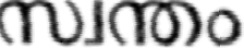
സ്വന്തം
